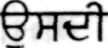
ਉਸਦੀ
